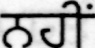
ਨਹੀਂ
